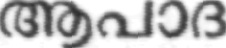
ആപാദ
